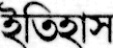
ইতিহাস
